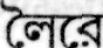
লৈরে
